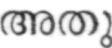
അതു
